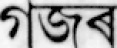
গজৰ
